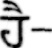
ਹੈ-
